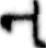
ન
